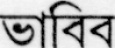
ভাবিব
